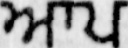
ਆਪ
